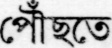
পৌঁছতে
